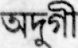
অদুগী
